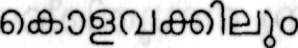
കൊളവക്കിലും
